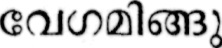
വേഗമിങ്ങു
